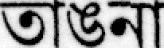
তাঙনা
